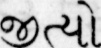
જીત્યો
